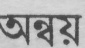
অন্বয়
